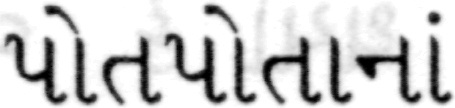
પોતપોતાનાં
